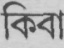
কিবা
